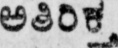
ಅತಿರಿಕ್ತ
